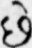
છે
